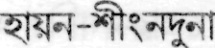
হায়ন-শীংনদুনা
